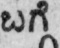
ಬಗ್ಗೆ
